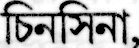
চিনসিনা,
